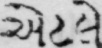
એટલે
